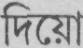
দিয়ো
